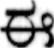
ಈ
